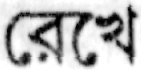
রেখে
